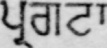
ਪ੍ਰਗਟਾ
